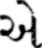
એ
